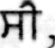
ਸੀ,
